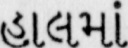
હાલમાં
